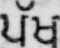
ਪੱਖ
